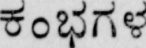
ಕಂಭಗಳ
